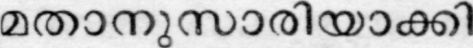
മതാനുസാരിയാക്കി
